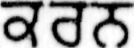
ਕਰਨ
